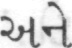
અને
